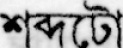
শব্দটো
